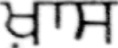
ਖ਼ਾਸ
